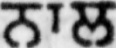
ਨਾਲ
